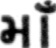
માં
